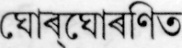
ঘোৰ্‌ঘোৰণিত
